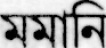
মমানি
